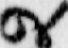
જ
